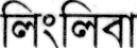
লিংলিবা
